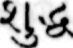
શુદ્ધ
